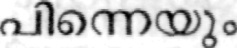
പിന്നെയും
